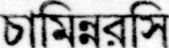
চামিন্নরসি
